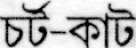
চৰ্ট-কাট
